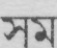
সম
